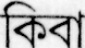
কিবা
